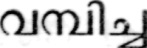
വമ്പിച്ച
